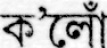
ক'লোঁ
